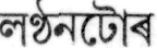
লণ্ঠনটোৰ
